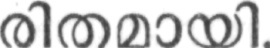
രിതമായി.
